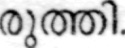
രുത്തി.
